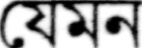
যেমন
